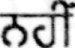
ਨਹੀਂ
